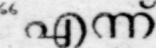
"എന്ന്
